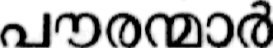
പൌരന്മാര്‍
